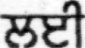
ਲਈ
